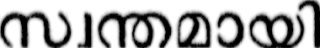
സ്വന്തമായി
